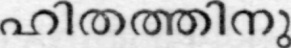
ഹിതത്തിനു
